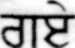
ਗਏ
